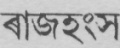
ৰাজহংস
